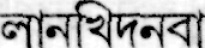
লানখিদনবা
